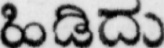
ಹಿಡಿದು
